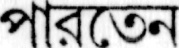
পারতেন
